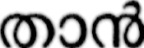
താന്‍
